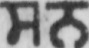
ਸਨ
